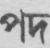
পদ
